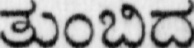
ತುಂಬಿದ
